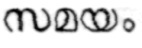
സമയം
